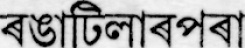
ৰঙাটিলাৰপৰা
